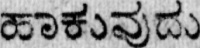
ಹಾಕುವುದು
